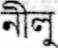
নীলু
